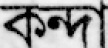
কন্দা
